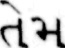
તેમ
